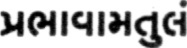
પ્રભાવામતુલં
